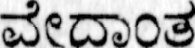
ವೇದಾಂತ
